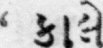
'કાલે
